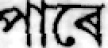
পাৰে
